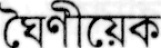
ঘৈণীয়েক
